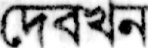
দেবখন
